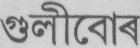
গুলীবোৰ
